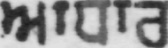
ਆਧਾਰ
